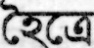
হৈত্রে
